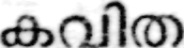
കവിത
